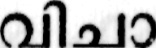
വിചാ
